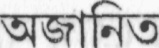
অজানিত
